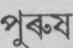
পুৰুষ
